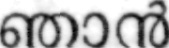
ഞാന്‍
